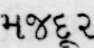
મજદૂર
